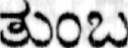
ತುಂಬ
